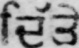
ਦਿੱਤੇ
